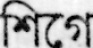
শিগে
